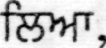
ਲਿਆ,
